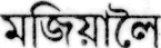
মজিয়ালৈ
